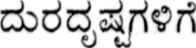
ದುರದೃಷ್ಟಗಳಿಗೆ
